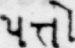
પત્તો
